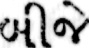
બીજે
